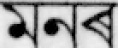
মনৰ
